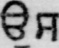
ਉਸ
